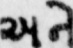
અને
